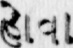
હોવા
